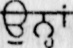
ਉਨ੍ਹਾਂ
